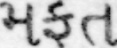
મફત
